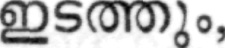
ഇടത്തും,
